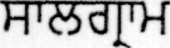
ਸਾਲਗ੍ਰਾਮ
